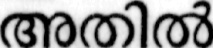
അതില്‍
